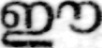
ഈ
